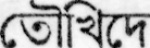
তৌখিদে
